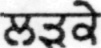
ਲੜਕੇ
